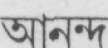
আনন্দ
